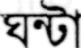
ঘন্টা
